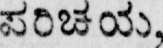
ಪರಿಚಯ,
